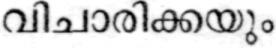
വിചാരിക്കയും
